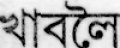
খাবলৈ
